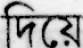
দিয়ে
